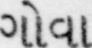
ગોવા
